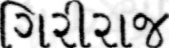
ગિરીરીજ
